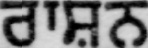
ਰਾਸ਼ਨ
